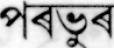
পৰভুৰ
